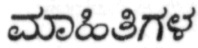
ಮಾಹಿತಿಗಳ
